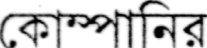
কোম্পানির
